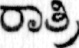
ರಾತ್ರಿ
